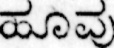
ಹೂವು
